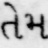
તેમ
